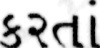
કરતાં
